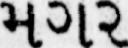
મગર
